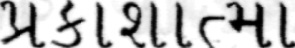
પ્રકાશાત્મા
